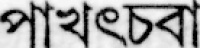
পাখৎচবা
